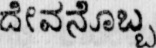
ದೇವನೊಬ್ಬ
